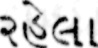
રહેલા
